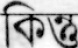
কিন্তু
